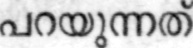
പറയുന്നത്
